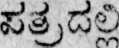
ಪತ್ರದಲ್ಲಿ
